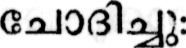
ചോദിച്ചു:
